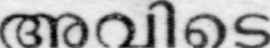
അവിടെ
